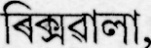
ৰিক্সৱালা,
